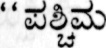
"ಪಶ್ಚಿಮ
